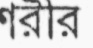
শরীর
